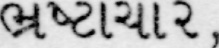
ભ્રષ્ટાચાર,
